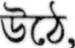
উঠে,
